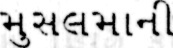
મુસલમાની
